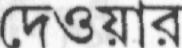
দেওয়ার
